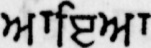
ਆਇਆ
